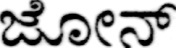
ಜೋನ್
